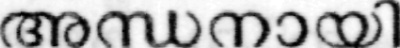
അന്ധനായി
